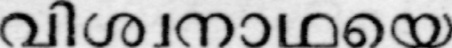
വിശ്വനാഥയെ
